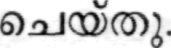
ചെയ്തു.
